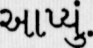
આપ્યું.
